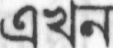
এখন
